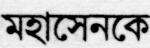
মহাসেনকে
